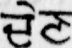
ਦੇਣ
